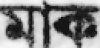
মাক
